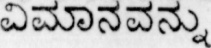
ವಿಮಾನವನ್ನು
